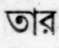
তার
